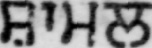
ਸ਼ਾਮਲ
